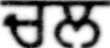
ਚਲ
